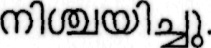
നിശ്ചയിച്ചു.
